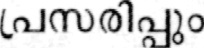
പ്രസരിപ്പും
